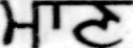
ਮਾਣ
